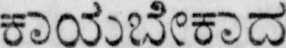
ಕಾಯಬೇಕಾದ
